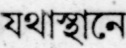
যথাস্থানে
